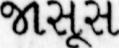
જાસૂસ
